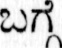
ಬಗ್ಗೆ
